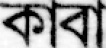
কাবা
